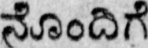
ನೊಂದಿಗೆ
